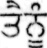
ਤੈਨੂੰ
